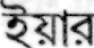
ইয়ার
